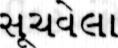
સૂચવેલા
